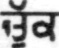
ਚੁੱਕ
